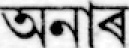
অনাৰ
